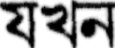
যখন
